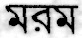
মরম
